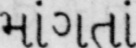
માંગતાં
